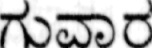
ಗುವಾರ
